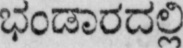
ಭಂಡಾರದಲ್ಲಿ
